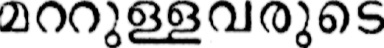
മററുള്ളവരുടെ
